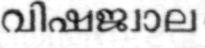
വിഷജ്വാല
